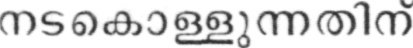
നടകൊള്ളുന്നതിന്
